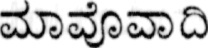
ಮಾವೊವಾದಿ
